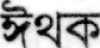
ঈথক
